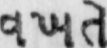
વખતે
